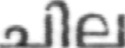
ചില
